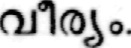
വീര്യം.
